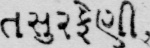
તસુરફેણી,જલેબી
